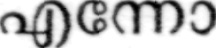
എന്നോ
